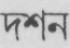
দশন
